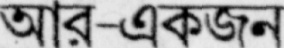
আর-একজন
